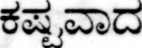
ಕಷ್ಟವಾದ
